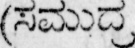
(ಸಮುದ್ರ
